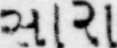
સારા
